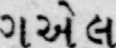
ગએલ
